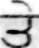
ਤੇ
